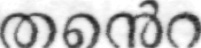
തന്റെ
